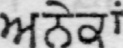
ਅਨੇਕਾਂ
